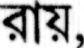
রায়,
